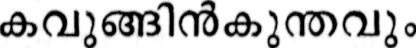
കവുങ്ങിന്‍കുന്തവും
